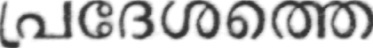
പ്രദേശത്തെ
